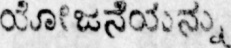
ಯೋಜನೆಯನ್ನು
